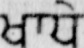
ਖਾਧੇ
